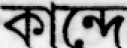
কান্দে
